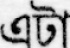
এটা
